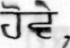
ਹੋਵੇ,
